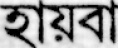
হায়বা
